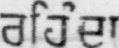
ਰਹਿੰਦਾ
